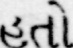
હતો
